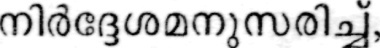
നിര്‍ദ്ദേശമനുസരിച്ച്,
